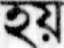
হয়
